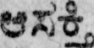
ಆಸಕ್ತಿ
